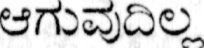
ಆಗುವುದಿಲ್ಲ
